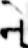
ને
